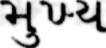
મુખ્ય
